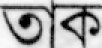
তাক
